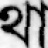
থা
